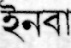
ইনবা
